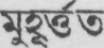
মুহূৰ্ত্তত
